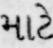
માટે
